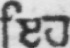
ਇਹ
